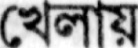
খেলায়
